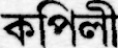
কপিলী
